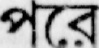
পরে
